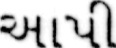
આપી
